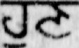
ਹੁਣ
